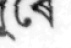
দূৰে
